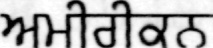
ਅਮੀਰੀਕਨ
